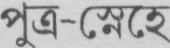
পুত্ৰ-স্নেহে
